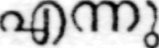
എന്നു
